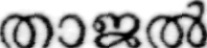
താജല്‍
